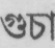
গুচা
